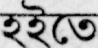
হইতে
